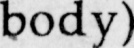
body)
